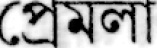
প্রেমলা
